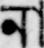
না
